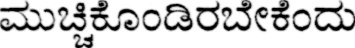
ಮುಚ್ಚಿಕೊಂಡಿರಬೇಕೆಂದು
